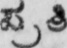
ಪ್ರತಿ
